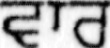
ਵਾਰ
